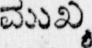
ಮುಖ್ಯ
